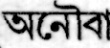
অনৌবা
